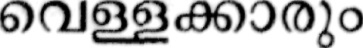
വെള്ളക്കാരും
